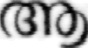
ആ
